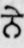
ਨੇ
